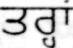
ਤਰ੍ਹਾਂ
